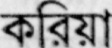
করিয়া
